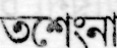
তশেংনা
